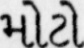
મોટો
